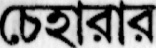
চেহারার
